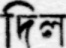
দিল
